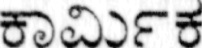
ಕಾರ್ಮಿಕ
